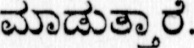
ಮಾಡುತ್ತಾರೆ.
